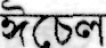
ঈচেল
